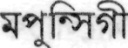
মপুন্সিগী
